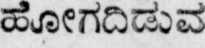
ಹೋಗದಿಡುವ
